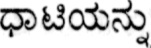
ಧಾಟಿಯನ್ನು
